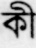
কী
